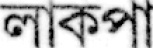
লাকপা
